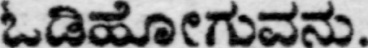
ಓಡಿಹೋಗುವನು.
